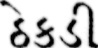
ઠેકડી
